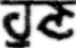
ਹੁਣ
